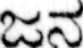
ಜನ
